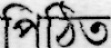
পিঠিত
